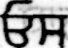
ਓਸ
